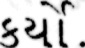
કર્યો.
